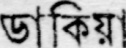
ডাকিয়া
